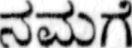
ನಮಗೆ
